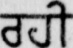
ਰਹੀ
